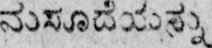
ಮಸೂದೆಯನ್ನು
